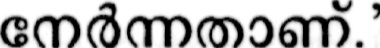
നേര്‍ന്നതാണ്.’
